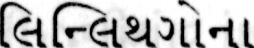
લિન્લિથગોના
